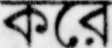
করে
